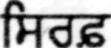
ਸਿਰਫ਼
